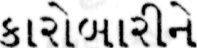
કારોબારીને
